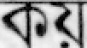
কয়
